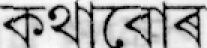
কথাবোৰ
